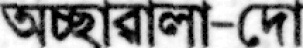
অচ্ছাৱালা-দো
